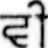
ਵੀ
